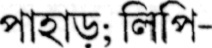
পাহাড়;লিপি-
